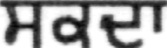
ਸਕਦਾ
